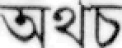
অথচ
